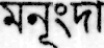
মনূংদা
